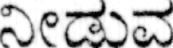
ನೀಡುವ
